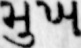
મુખ
